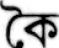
কৈ
